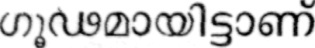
ഗൂഢമായിട്ടാണ്
